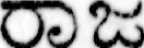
ರಾಜ
